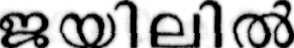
ജയിലില്‍
